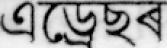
এড্ৰেছৰ
